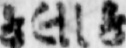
કલાક
